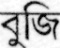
বুজি
